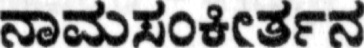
ನಾಮಸಂಕೀರ್ತನ
